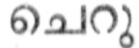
ചെറു
